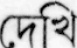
দেখি
